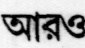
আরও
